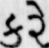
કરે
